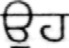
ਉਹ
